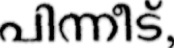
പിന്നീട്,
